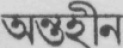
অন্তহীন
